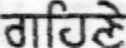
ਗਹਿਣੇ
